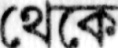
থেকে
